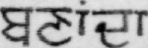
ਬਣਾਂਦਾ
